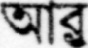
আরু
